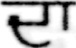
ਦਾ
